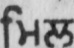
ਮਿਲ
